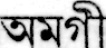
অমগী
